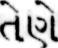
તેણે
